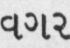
વગર
